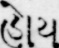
હોય
